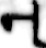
ન
